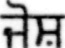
ਜੋਸ਼
